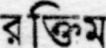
রক্তিম
